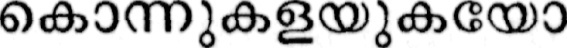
കൊന്നുകളയുകയോ
